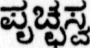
ಪೃಚ್ಛಸ್ವ
